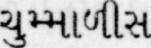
ચુમ્માળીસ
